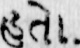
હતો.
